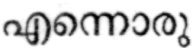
എന്നൊരു
